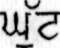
ਘੁੱਟ
